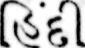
હિંદી
